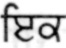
ਇਕ
